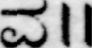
ವ||
